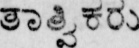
ತಾತ್ವಿಕರು
